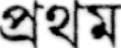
প্রথম
